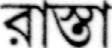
রাস্তা
